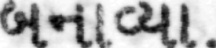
બનાવ્યા.
